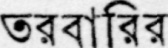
তরবারির
